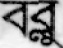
বব্লু
